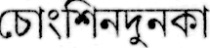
চোংশিনদুনকা
